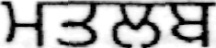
ਮਤਲਬ
